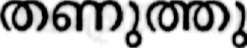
തണുത്തു
